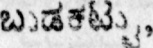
ಬುಡಕಟ್ಟು,
